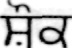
ਸ਼ੌਕ
